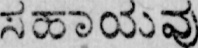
ಸಹಾಯವು
